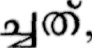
ച്ചത്,
